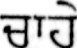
ਚਾਹੇ
